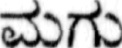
ಮಗು
